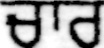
ਚਾਰ
